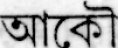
আকৌ
